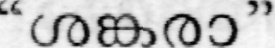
"ശങ്കരാ"
